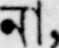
না,
